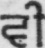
ਵੀ
